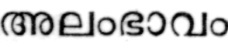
അലംഭാവം
